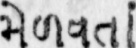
મેળવતાં
